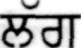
ਲੱਗ
